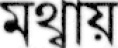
মথ্বায়
